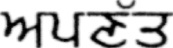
ਅਪਣੱਤ
